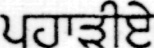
ਪਹਾੜੀਏ
